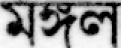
মঙ্গল
